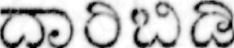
ದಾರಿಬಿಡಿ
